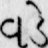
વડે
